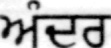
ਅੰਦਰ
